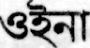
ওইনা
